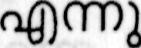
എന്നു
